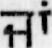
ਜਾਂ
